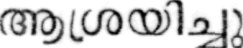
ആശ്രയിച്ചു
